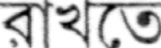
রাখতে
